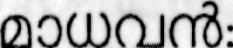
മാധവന്‍:
